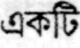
একটি
